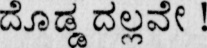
ದೊಡ್ಡದಲ್ಲವೇ!
